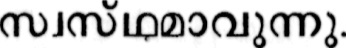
സ്വസ്ഥമാവുന്നു.
